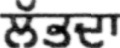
ਲੱਭਦਾ
